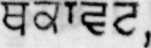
ਥਕਾਵਟ,
